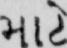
માટે
